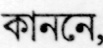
কাননে,
